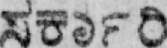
ಸರ್ಕಾರಿ
